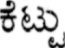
ಕೆಟ್ಟು
